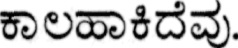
ಕಾಲಹಾಕಿದೆವು.
